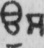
ਉਸ
